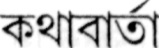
কথাবার্তা
